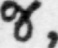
જ,
